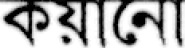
কয়ানো
